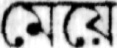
মেয়ে
